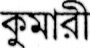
কুমারী
